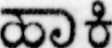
ಹಾಕಿ
